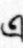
এ
